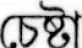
চেষ্টা
